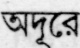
অদূরে
